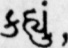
કહ્યું,
